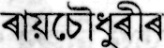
ৰায়চৌধুৰীৰ
